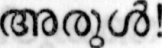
അരുള്‍!
